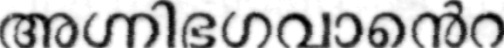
അഗ്നിഭഗവാന്റെ
